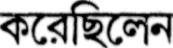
করেছিলেন
